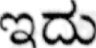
ಇದು
